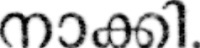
നാക്കി.
